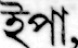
ইপা,
